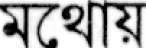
মথোয়
